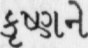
કૃષ્ણને
